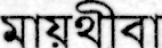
মায়থীবা
